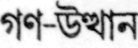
গণ-উত্থান
